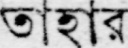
তাহার
